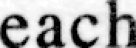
each
